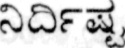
ನಿರ್ದಿಷ್ಟ
